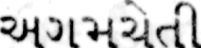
અગમચેતી
